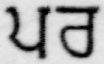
ਪਰ
